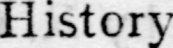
History
